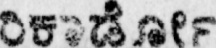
ರಿಕಾರ್ಡೋ
